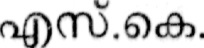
എസ്.കെ.
